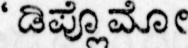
‘ಡಿಪ್ಲೊಮೋ
